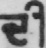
ਦੀ
